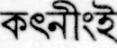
কৎনীংই
